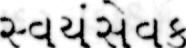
સ્વયંસેવક
